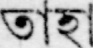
তাহা
